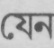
যেন
